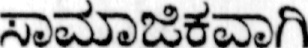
ಸಾಮಾಜಿಕವಾಗಿ
